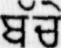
ਬੱਚੇ
